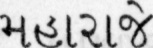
મહારાજે
